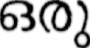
ഒരു
